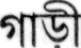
গাড়ী
